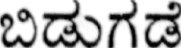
ಬಿಡುಗಡೆ
